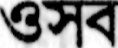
ওসব
